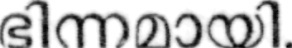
ഭിന്നമായി.
